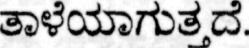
ತಾಳೆಯಾಗುತ್ತದೆ.
